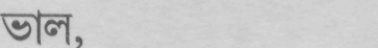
ভাল,
